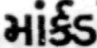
માંર્કડ
